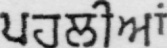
ਪਹਲੀਆਂ
